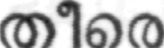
തീരെ
